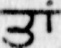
ਤਾਂ
